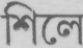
শিলে
